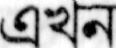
এখন
